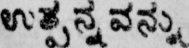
ಉತ್ಪನ್ನವನ್ನು
